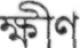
ক্ষীণ
